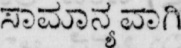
ಸಾಮಾನ್ಯವಾಗಿ
